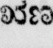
ಖಣ
